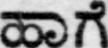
ಹಾಗೆ
